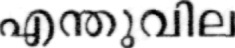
എന്തുവില
